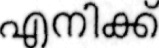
എനിക്ക്
